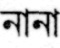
নানা
